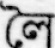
লৈ
